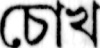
চোখ
